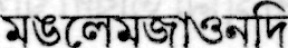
মঙলেমজাওনদি
